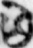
છે
